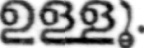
ഉള്ളൂ.
